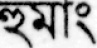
হুমাং
